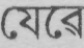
যেৱে
